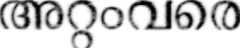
അറ്റംവരെ
